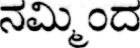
ನಮ್ಮಿಂದ
